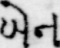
બેન
